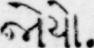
જોયો.
